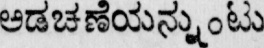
ಅಡಚಣೆಯನ್ನುಂಟು
